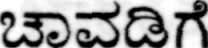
ಚಾವಡಿಗೆ
